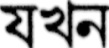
যখন
